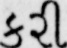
કરી
